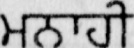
ਮਨਾਹੀ
